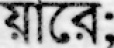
য়ারে;
